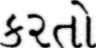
કરતો
